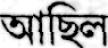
আছিল
